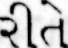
રીતે
